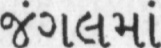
જંગલમાં
